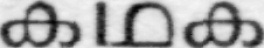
കഥക
